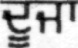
ਦੂਜਾ
